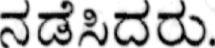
ನಡೆಸಿದರು.
